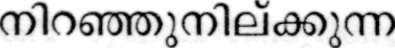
നിറഞ്ഞുനില്ക്കുന്ന
